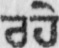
ਰਹੇ
